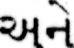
અને
